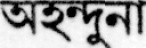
অহন্দুনা
